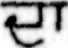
ਦਾ
